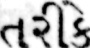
તરીકે
